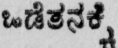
ಒಡೆತನಕ್ಕೆ
